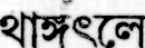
থাঙ্গৎলে
